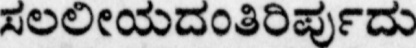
ಸಲಲೀಯದಂತಿರಿರ್ಪುದು
